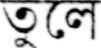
তুলে
